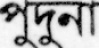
পুদুনা
